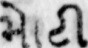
મોટી
